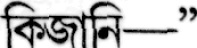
কিজানি-"
